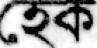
হেক
